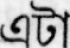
এটা
